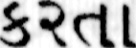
કરતા
